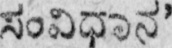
ಸಂವಿಧಾನ’
